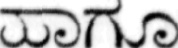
ಹಾಗೂ
